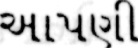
આપણી
